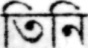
তিনি
